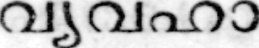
വ്യവഹാ
